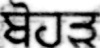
ਬੋਹੜ
